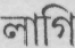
লাগি
